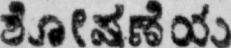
ಶೋಷಣೆಯ
